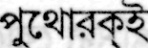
পুথোরকই
